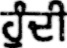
ਹੁੰਦੀ
